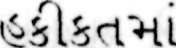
હકીકતમાં
